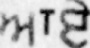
ਆਏ
